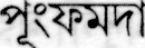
পূংফমদা
